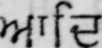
ਆਦਿ
